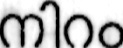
നിറം
